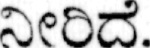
ನೀರಿದೆ.
